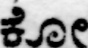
ಕೋ
